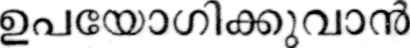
ഉപയോഗിക്കുവാന്‍
